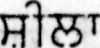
ਸ਼ੀਲਾ
